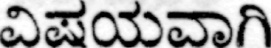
ವಿಷಯವಾಗಿ
